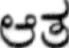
ಆತ
